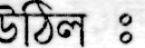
উঠিলঃ
